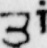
ਤਾਂ
